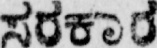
ಸರಕಾರ
